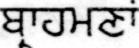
ਬ੍ਰਾਹਮਣਾਂ
